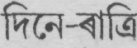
দিনে-ৰাত্ৰি
